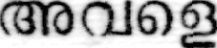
അവളെ
